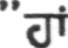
''ਹਾਂ
